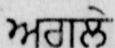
ਅਗਲੇ
